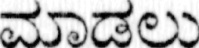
ಮಾಡಲು
